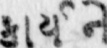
કાર્યને
